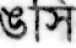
ঙসি
